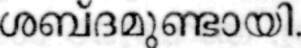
ശബ്ദമുണ്ടായി.
